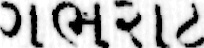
ગભરાટ
